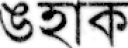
ঙহাক
